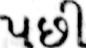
પછી
